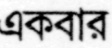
একবার
